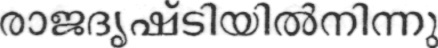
രാജദൃഷ്ടിയില്‍നിന്നു
